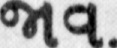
જાવ.
